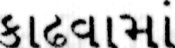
કાઢવામાં
